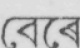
বেৰে
